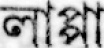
লাপ্পা
